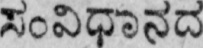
ಸಂವಿಧಾನದ
